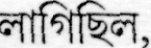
লাগিছিল,
